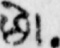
છો.
